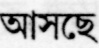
আসছে
